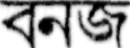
বনজ
